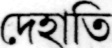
দেহাতি
